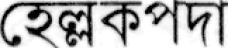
হেল্লকপদা
